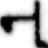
ન
